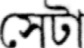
সেটা
